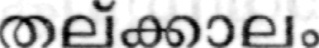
തല്ക്കാലം
